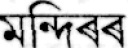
মন্দিৰৰ
